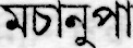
মচানুপা
